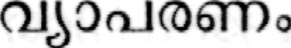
വ്യാപരണം
